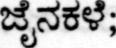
ಜೈನಕಳೆ;
